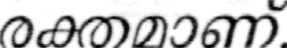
രക്തമാണ്.
